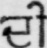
ਦੀ
